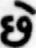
છે
